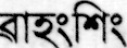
ৱাহংশিং
